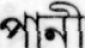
পানী
